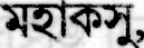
মহাকসু,
